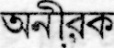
অনীরক
